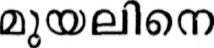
മുയലിനെ
